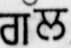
ਗੱਲ
